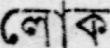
লোক
